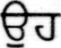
ਉਹ
